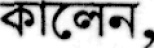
কালেন,
